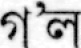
গ'ল
